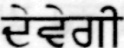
ਦੇਵੇਗੀ
